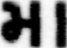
મા
